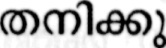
തനിക്കു
